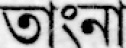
তাংনা
